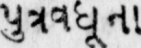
પુત્રવધૂના
